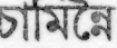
চামিন্নৈ
